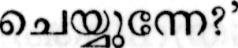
ചെയ്യുന്നേ?’
